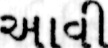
આવી
